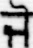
ਜੋ
